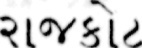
રાજકોટ
